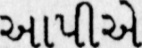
આપીએ
